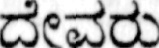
ದೇವರು
